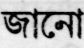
জানো
